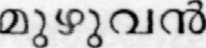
മുഴുവന്‍
